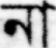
না
